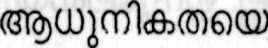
ആധുനികതയെ
